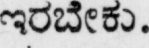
ಇರಬೇಕು.
